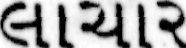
લાચાર
